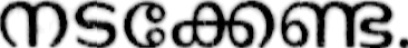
നടക്കേണ്ട.
